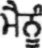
ਮੈਨੂੰ
